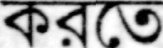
করতে
